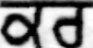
ਕਰ
